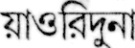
য়াওরিদুনা
